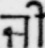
ਜੀ
